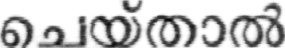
ചെയ്താല്‍
